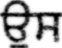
ਉਸ
